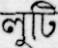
লুটি
